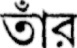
তাঁর
